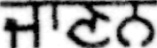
ਜਾਣਨ
